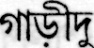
গাড়ীদু
